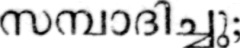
സമ്പാദിച്ചു;
